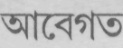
আবেগত
